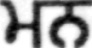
ਮਨ
